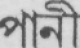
পানী
